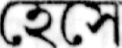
হেসে
